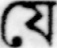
যে
